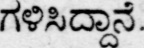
ಗಳಿಸಿದ್ದಾನೆ.
